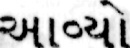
આવ્યો
